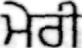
ਮੇਰੀ
